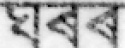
ঘৰৰ
